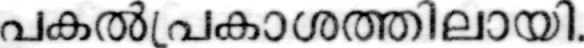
പകല്‍പ്രകാശത്തിലായി.
